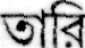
তারি
